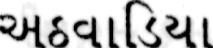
અઠવાડિયા
